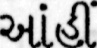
આંહીં
